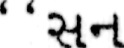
"સન
